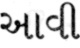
આવી
